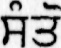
ਸੰਤੋ
